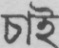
চাই
